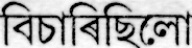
বিচাৰিছিলো
